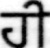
ਹੀ
